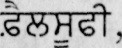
ਫ਼ੈਲਸੂਫੀ,
